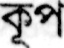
কূপ
